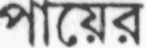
পায়ের
